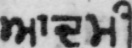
ਆਦਮੀ
